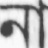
না
